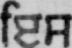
ਇਸ
